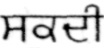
ਸਕਦੀ
